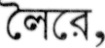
লৈরে,
